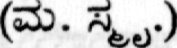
(ಮ.ಸ್ಮೃ.)
